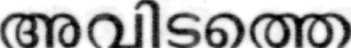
അവിടത്തെ
